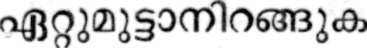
ഏറ്റുമുട്ടാനിറങ്ങുക
